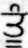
ਤੂੰ
